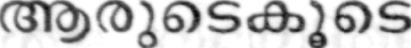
ആരുടെകൂടെ
